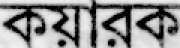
কয়ারক
